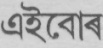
এইবোৰ
